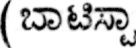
(ಬಾಟಿಸ್ಟಾ
